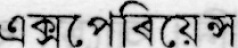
এক্সপেৰিয়েন্স
